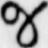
જ
